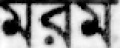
মরম
